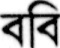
ববি
